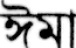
ঈম
